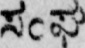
ಸಂಘ
